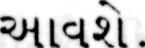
આવશે.
